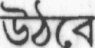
উঠবে
